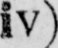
iv)
